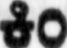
ಕಿ೦
